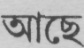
আছে
